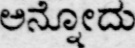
ಅನ್ನೋದು
